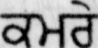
ਕਮਰੇ
